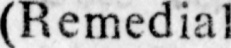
(Remedial
